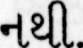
નથી.
